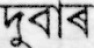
দুবাৰ
